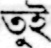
তুই
